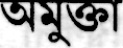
অমুক্তা
